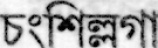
চংশিল্লগা
